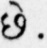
છે.
